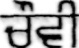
ਚੌਵੀ
